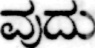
ವುದು
